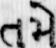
તમે
